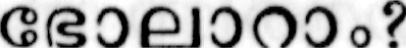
ഭോലാറാം?
